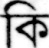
কি
